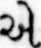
એ
